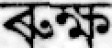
ৰুক্ষ
